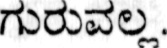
ಗುರುವಲ್ಲ.
